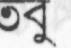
তবু
